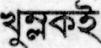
খুম্লকই
